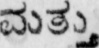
ಮತ್ತು
